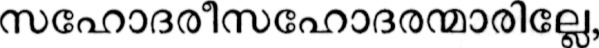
സഹോദരീസഹോദരന്മാരില്ലേ,
